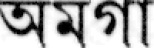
অমগা
